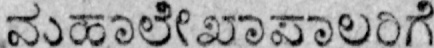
ಮಹಾಲೇಖಾಪಾಲರಿಗೆ
